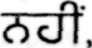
ਨਹੀਂ,
